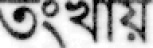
তংখায়
